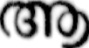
ആ
